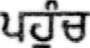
ਪਹੁੰਚ
